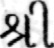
શ્રી
